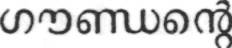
ഗൗണ്ഡന്റെ
